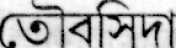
তৌবসিদা
